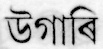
উগাৰি
